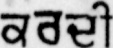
ਕਰਦੀ
